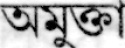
অমুক্তা
